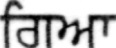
ਗਿਆ
